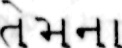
તેમના
